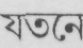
যতনে
